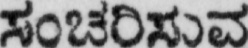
ಸಂಚರಿಸುವ
